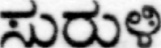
ಸುರುಳಿ
